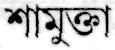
শামুক্তা
